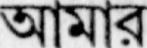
আমার
